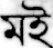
মই
